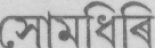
সোমধিৰি
